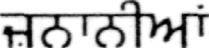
ਜ਼ਨਾਨੀਆਂ
